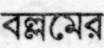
বল্লমের
